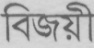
বিজয়ী
